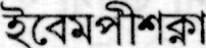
ইবেমপীশক্না
